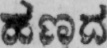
ಹಣದ
